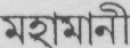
মহামানী
